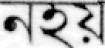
নহয়
